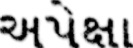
અપેક્ષા
